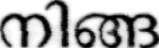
നിങ്ങ
